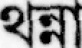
থন্না
